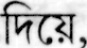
দিয়ে,
